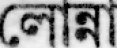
লোন্না
